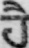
ਹੈ
